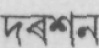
দৰশন
